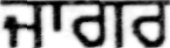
ਜਾਗਰ
